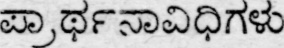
ಪ್ರಾರ್ಥನಾವಿಧಿಗಳು
